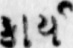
કાર્ય
